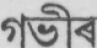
গভীৰ
